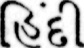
હિંદી
